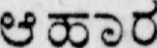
ಆಹಾರ
